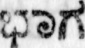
ಭಾಗ
